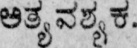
ಅತ್ಯವಶ್ಯಕ.
